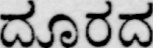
ದೂರದ
